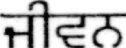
ਜੀਵਨ
